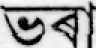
ভৰা
